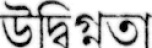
উদ্বিগ্নতা
